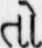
તો
